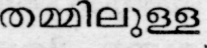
തമ്മിലുള്ള
